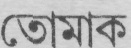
তোমাক
